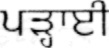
ਪੜ੍ਹਾਈ
